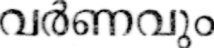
വര്‍ണവും
